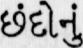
છંદોનું
